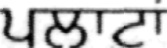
ਪਲਾਟਾਂ
